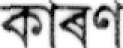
কাৰণ
